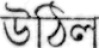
উঠিল
